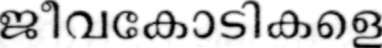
ജീവകോടികളെ
